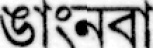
ঙাংনবা
